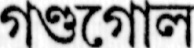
গণ্ডগোল
